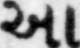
આ
